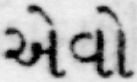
એવો
